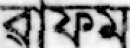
ৱাফম
